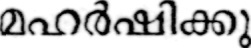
മഹര്‍ഷിക്കു
